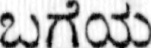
ಬಗೆಯ
